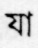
যা
